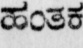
ಹಂತಕ
